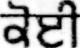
ਕੋਈ
